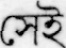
সেই
